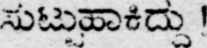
ಸುಟ್ಟುಹಾಕಿದ್ದು!
